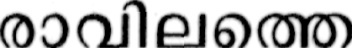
രാവിലത്തെ
